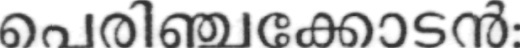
പെരിഞ്ചക്കോടന്‍:
